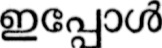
ഇപ്പോള്‍
